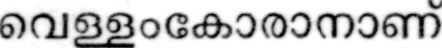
വെള്ളംകോരാനാണ്
